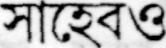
সাহেবও
